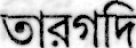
তারগদি
